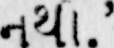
નથી.'
